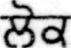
ਲੋਕ
